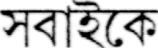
সবাইকে
